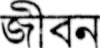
জীবন
